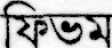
ফিভম
